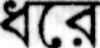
ধরে
